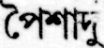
পৈশাদু
